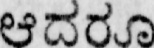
ಆದರೂ
